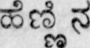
ಹೆಣ್ಣಿನ
